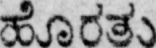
ಹೊರತು
